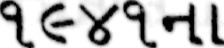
૧૯૪૧ના
